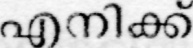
എനിക്ക്
